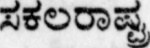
ಸಕಲರಾಷ್ಟ್ರ
